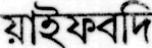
য়াইফবদি
